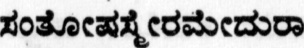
ಸಂತೋಷಸ್ಮೇರಮೇದುರಾ
